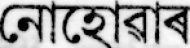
নোহোৱাৰ
